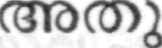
അതു
